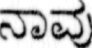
ನಾವು
